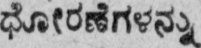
ಧೋರಣೆಗಳನ್ನು
